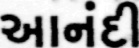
આનંદી
